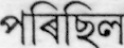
পৰিছিল
